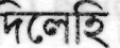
দিলেহি
